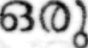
ഒരു
